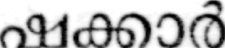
ഷക്കാര്‍
